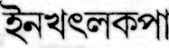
ইনখৎলকপা
